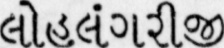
લોહલંગરીજી
